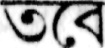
তবে
